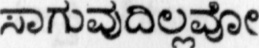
ಸಾಗುವುದಿಲ್ಲವೋ
